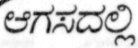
ಆಗಸದಲ್ಲಿ
